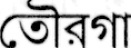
তৌরগা
